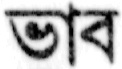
ভাব
